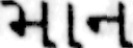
માન
